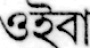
ওইবা
